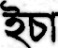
ইচা
